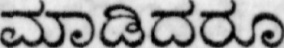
ಮಾಡಿದರೂ
